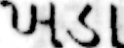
ખડા
